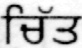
ਚਿੱਤ
